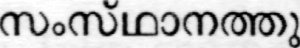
സംസ്ഥാനത്തു
